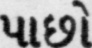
પાછો
